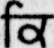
ਕਿ
